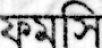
ফমসি
